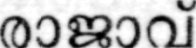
രാജാവ്
